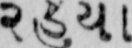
રહ્યા
